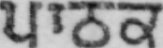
ਪਾਠਕ
